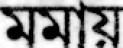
মমায়
